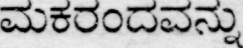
ಮಕರಂದವನ್ನು
